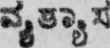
ವ್ಯತ್ಯಾಸ
